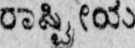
ರಾಷ್ಟ್ರೀಯ
